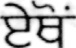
ਏਥੋਂ
